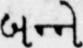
બન્ને
